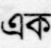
এক
